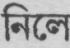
নিলে
